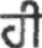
ਹੀ
